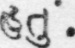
હતું.
